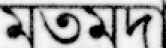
মতমদা
